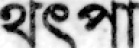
থৎপা
